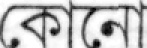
কোনো
